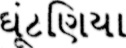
ઘૂંટણિયા
